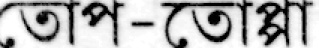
তোপ-তোপ্পা
